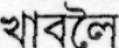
খাবলৈ
